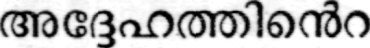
അദ്ദേഹത്തിന്റെ
